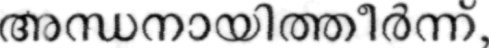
അന്ധനായിത്തീര്‍ന്ന്,
